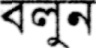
বলুন
